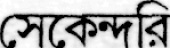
সেকেন্দরি
